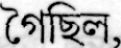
গৈছিল,
